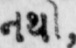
નથી,
